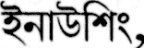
ইনাউশিং,
